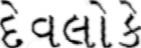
દેવલોકે
